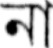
না
